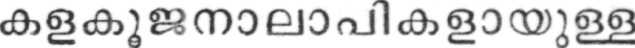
കളകൂജനാലാപികളായുള്ള
